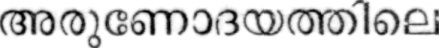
അരുണോദയത്തിലെ
